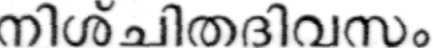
നിശ്ചിതദിവസം
